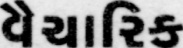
વૈચારિક
